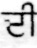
ਦੀ
